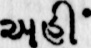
અહીં
